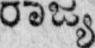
ರಾಜ್ಯ
